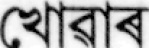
খোৱাৰ
